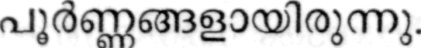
പൂര്‍ണ്ണങ്ങളായിരുന്നു.
